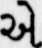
એ
